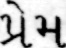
પ્રેમ
